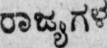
ರಾಜ್ಯಗಳ
